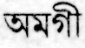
অমগী
